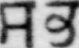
ਸਭ
